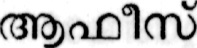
ആഫീസ്
